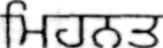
ਮਿਹਨਤ
